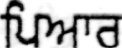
ਪਿਆਰ
